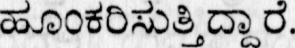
ಹೂಂಕರಿಸುತ್ತಿದ್ದಾರೆ.
